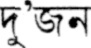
দু’জন
